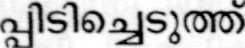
പ്പിടിച്ചെടുത്ത്
